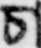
চা
